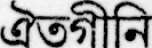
ঐতগীনি
